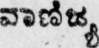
ವಾಣಿಜ್ಯ
